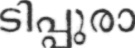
ടിപ്പുരാ
